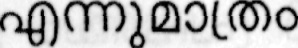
എന്നുമാത്രം
